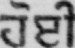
ਹੋਈ
